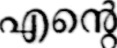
എന്റെ
